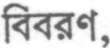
বিবরণ,
